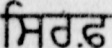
ਸਿਰਫ਼
